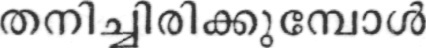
തനിച്ചിരിക്കുമ്പോള്‍
